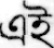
এই
